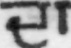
ਦਾ
